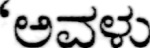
'ಅವಳು
